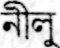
নীলু
